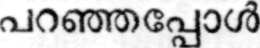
പറഞ്ഞപ്പോള്‍
